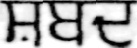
ਸ਼ਬਦ
